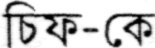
চিফ-কে
